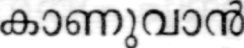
കാണുവാന്‍
